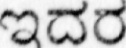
ಇದರ
